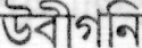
উবীগনি
